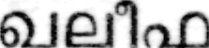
ഖലീഫ
